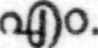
എം.
